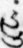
હું
